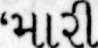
'મારી
